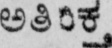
ಅತಿರಿಕ್ತ
